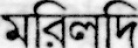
মরিসদি
